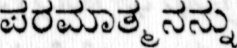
ಪರಮಾತ್ಮನನ್ನು
